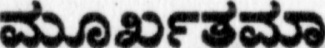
ಮೂರ್ಖತಮಾ
